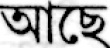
আছে
